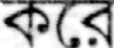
করে
